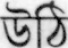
উঠি
